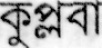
কুপ্লবা
